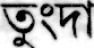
তুংদা
